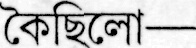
কৈছিলো-
